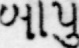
બાપુ
